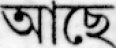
আছে
